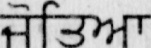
ਜੋਤਿਆ
